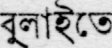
বুলাইতে
